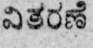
ವಿತರಣೆ
